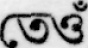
তেওঁ
